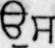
ਉਸ
